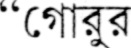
“গোরুর
